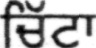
ਚਿੱਟਾ
